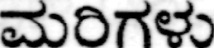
ಮರಿಗಳು
